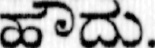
ಹೌದು.
